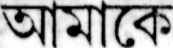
আমাকে
